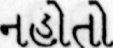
નહોતો
